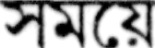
সময়ে
